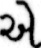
એ
